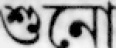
শুনো
